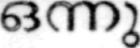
ഒന്നു
